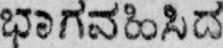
ಭಾಗವಹಿಸಿದ
